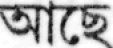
আছে
